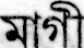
মাগী
